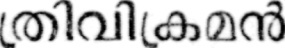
ത്രിവിക്രമന്‍
